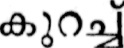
കുറച്ച്
